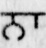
ਨਾ
